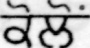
ਕੋਲੋਂ
